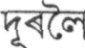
দূৰলৈ
